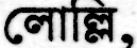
লোল্লি,
